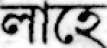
লাহে
